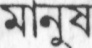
মানুষ
